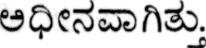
ಅಧೀನವಾಗಿತ್ತು.
